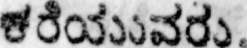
ಕರೆಯುವರು.
